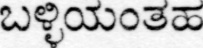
ಬಳ್ಳಿಯಂತಹ
